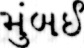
મુંબઈ
